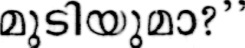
മുടിയുമാ?"
